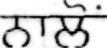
ਨਾਲੋਂ
